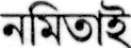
নমিতাই
